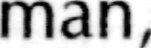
man,
